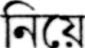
নিয়ে
